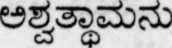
ಅಶ್ವತ್ಥಾಮನು
